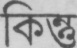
কিন্তু
